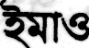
ইমাও
